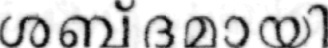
ശബ്ദമായി
